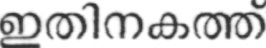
ഇതിനകത്ത്
